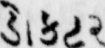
ડોક્ટર
